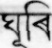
ঘূৰি
